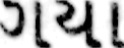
ગયા
